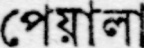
পেয়ালা
